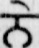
ਨੇ
